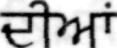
ਦੀਆਂ
